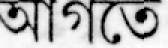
আগতে
